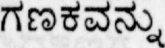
ಗಣಕವನ್ನು
